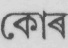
কোৰ
